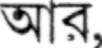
আর,
